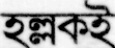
হল্লকই
